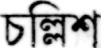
চল্লিশ
